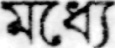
মধ্যে
